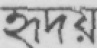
হৃদয়
